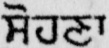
ਸੋਹਣਾ
